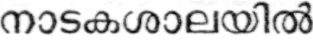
നാടകശാലയില്‍
